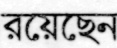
রয়েছেন
